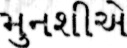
મુનશીએ
